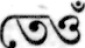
তেওঁ
